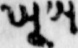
ખૂબ
